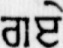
ਗਏ
